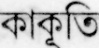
কাকূতি
